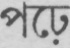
পঢ়ে
